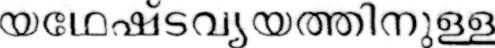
യഥേഷ്ടവ്യയത്തിനുള്ള
